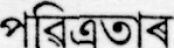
পৱিত্রতাৰ
